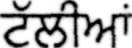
ਟੱਲੀਆਂ
